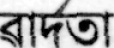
ৱার্দতা
